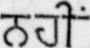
ਨਹੀਂ
